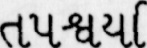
તપશ્વર્યા
